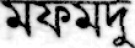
মফমদু
